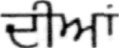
ਦੀਆਂ
